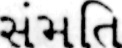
સંમતિ
